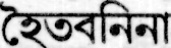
হৈতবনিনা
